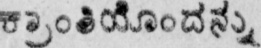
ಕ್ರಾಂತಿಯೊಂದನ್ನು
